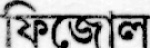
ফিজোল
